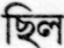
ছিল
